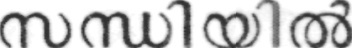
സന്ധിയില്‍
